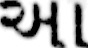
આ
